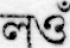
লওঁ
